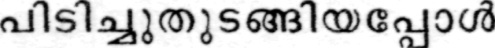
പിടിച്ചുതുടങ്ങിയപ്പോള്‍
